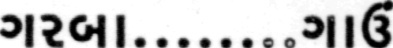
ગરબા........ગાઉં
